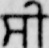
ਸੀ
